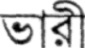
ভারী
